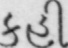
કહી
